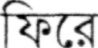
ফিরে
